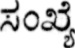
ಸಂಖ್ಯೆ
